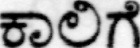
ಕಾಲಿಗೆ
